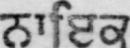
ਨਾਇਕ
